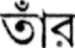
তাঁর
